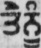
ਤੈਨੂੰ
